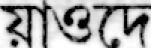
য়াওদে
